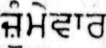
ਜ਼ੁੰਮੇਵਾਰ
